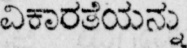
ವಿಕಾರತೆಯನ್ನು
